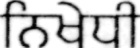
ਨਿਖੇਧੀ
